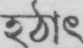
হঠাৎ
